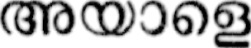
അയാളെ
